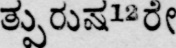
ತ್ಪುರುಷ12ರೇ
